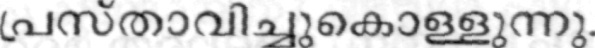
പ്രസ്താവിച്ചുകൊള്ളുന്നു.
